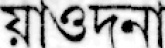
য়াওদনা
